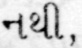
નથી,
